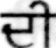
ਦੀ
